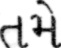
તમે
